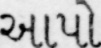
આપો
